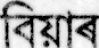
বিয়াৰ
